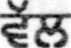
ਵੱਲ
